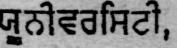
ਯੂਨੀਵਰਸਿਟੀ,
